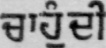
ਚਾਹੁੰਦੀ
